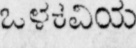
ಒಳಕಿವಿಯ
